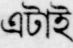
এটাই
